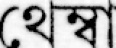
থেম্বা
